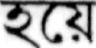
হয়ে
